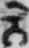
ਨੇ
